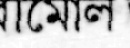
বীমোল
